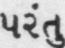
પરંતુ
